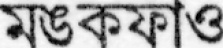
মঙকফাও
